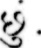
છું.
